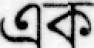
এক
